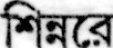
শিন্নরে
